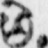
છે.
